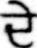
ਦੇ
